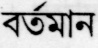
বর্তমান
